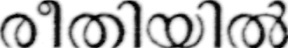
രീതിയില്‍
